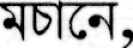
মচানে,
